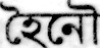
হৈনৌ
